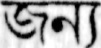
জন্য
